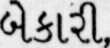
બેકારી,
